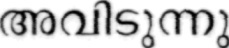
അവിടുന്നു
